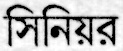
সিনিয়র
